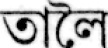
তালৈ
